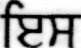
ਇਸ
